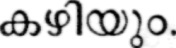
കഴിയും.
